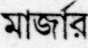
মার্জার
